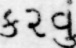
કરવું
